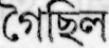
গৈছিল
